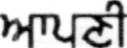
ਆਪਣੀ
